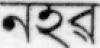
নহৱ
